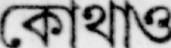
কোথাও
